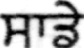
ਸਾਡੇ
